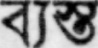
ব্যস্ত
